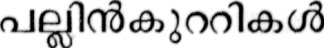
പല്ലിന്‍കുററികള്‍
